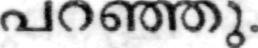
പറഞ്ഞു.
